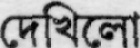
দেখিলো
